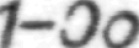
1-ാം
